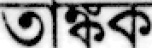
তাঙ্কক
